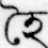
হৈ
